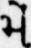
મેં
